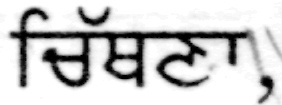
ਚਿੱਥਣਾ,
